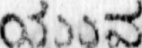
ಯುವ
